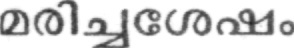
മരിച്ചശേഷം
